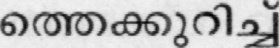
ത്തെക്കുറിച്ച്
